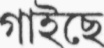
গাইছে
